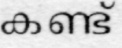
കണ്ട്
